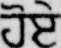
ਹੋਏ
